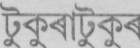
টুকুৰাটুকুৰ
